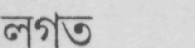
লগত
